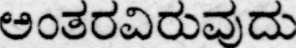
ಅಂತರವಿರುವುದು
